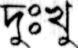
দুঃখু
